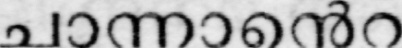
ചാന്നാന്റെ
